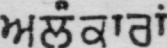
ਅਲੰਕਾਰਾਂ
